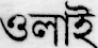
ওলাই
